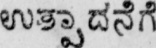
ಉತ್ಪಾದನೆಗೆ
